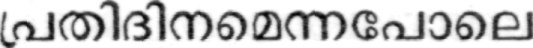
പ്രതിദിനമെന്നപോലെ
